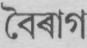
বৈৰাগ
